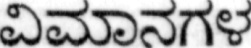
ವಿಮಾನಗಳ
